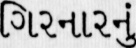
ગિરનારનું
